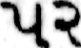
પર
